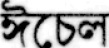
ঈচেল
